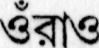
ওঁরাও
